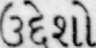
ઉદેશો
